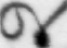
જ
